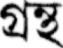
গ্রন্থ
